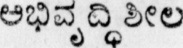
ಅಭಿವೃದ್ಧಿಶೀಲ
